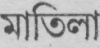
মাতিলা
